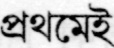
প্রথমেই
